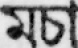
মচা
